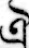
ঐ
